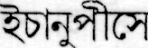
ইচানুপীসে
